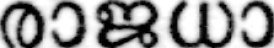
രാജധാ
